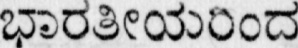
ಭಾರತೀಯರಿಂದ
